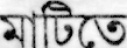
মাটিতে
